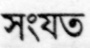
সংযত
